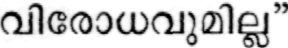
വിരോധവുമില്ല”
